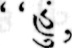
"હું,
